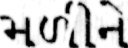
મળીને
